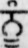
ਨੂੰ
